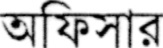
অফিসার
